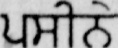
ਪਸੀਨੇ
